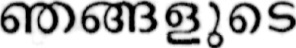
ഞങ്ങളുടെ
